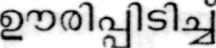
ഊരിപ്പിടിച്ച്
